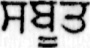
ਸਬੂਤ
